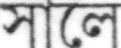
সালে
